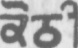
ਕੋਠੀ
